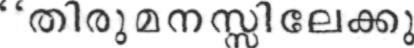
"തിരുമനസ്സിലേക്കു
